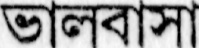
ভালবাসা
